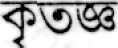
কৃতজ্ঞ
